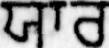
ਯਾਰ
